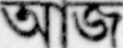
আজ
